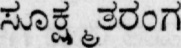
ಸೂಕ್ಷ್ಮತರಂಗ
